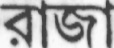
রাজা
